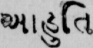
આહુતિ
